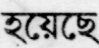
হয়েছে
